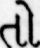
તો
